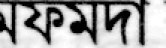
মফমদা
